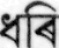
ধৰি
